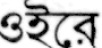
ওইরে
